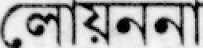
লোয়ননা
